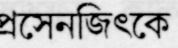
প্রসেনজিত্কে
